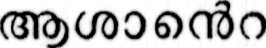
ആശാന്റെ
